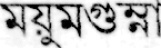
ময়ুমগুম্না
